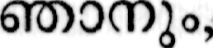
ഞാനും,
